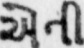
એની
